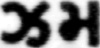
ઝમ
